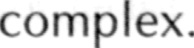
complex.
